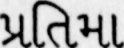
પ્રતિમા
